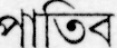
পাতিব
